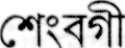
শেংবগী
